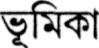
ভূমিকা
